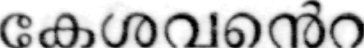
കേശവന്റെ
